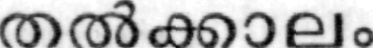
തല്‍ക്കാലം
